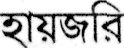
হায়জরি
